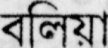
বলিয়া
